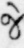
જે
